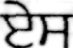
ਏਸ
